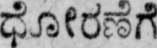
ಧೋರಣೆಗೆ
